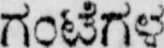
ಗಂಟೆಗಳ
